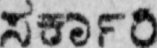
ಸರ್ಕಾರಿ
